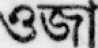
ওঝা
